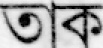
তাক
